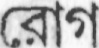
রোগ
